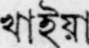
খাইয়া
